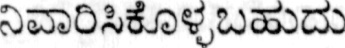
ನಿವಾರಿಸಿಕೊಳ್ಳಬಹುದು
